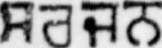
ਸਰਜਨ
